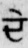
ਦੇ
